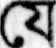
যে
